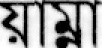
য়াম্না
